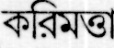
করিমত্তা
